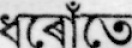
ধৰোঁতে
